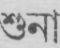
শুনা
